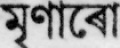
মৃণাৰো
